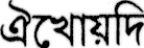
ঐখোয়দি
